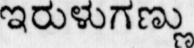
ಇರುಳುಗಣ್ಣು
